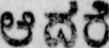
ಆದರೆ
